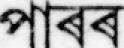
পাৰৰ
